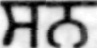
ਸਨ
